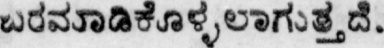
ಬರಮಾಡಿಕೊಳ್ಳಲಾಗುತ್ತದೆ.
